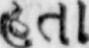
હતા
